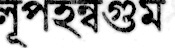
লূপহন্বগুম
